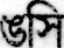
ঙসি
